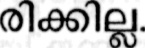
രിക്കില്ല.
